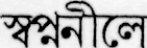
স্বপ্ননীলে
